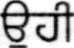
ਉਹੀ
